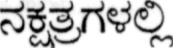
ನಕ್ಷತ್ರಗಳಲ್ಲಿ
